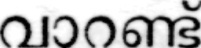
വാറണ്ട്
